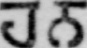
ਹਨ
